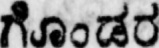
ಗೊಂಡರ
